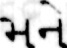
મને
